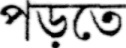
পড়তে
